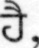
ਹੈ,
